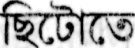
ছিটোতে
